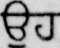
ਉਹ
